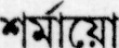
শর্মায়ো
